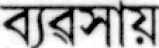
ব্যৱসায়
